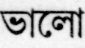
ভালো
